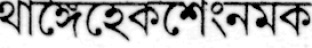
থাঙ্গৈহেকশেংনমক
